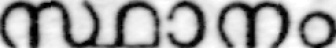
സ്ഥാനം
